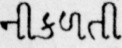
નીકળતી
